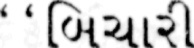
"બિચારી
